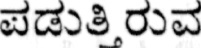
ಪಡುತ್ತಿರುವ
